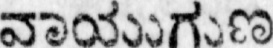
ವಾಯುಗುಣ
